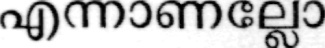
എന്നാണല്ലോ
